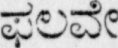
ಫಲವೇ
